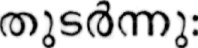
തുടര്‍ന്നു:
